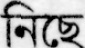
নিছে
